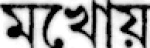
মখোয়
